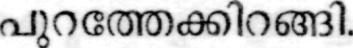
പുറത്തേക്കിറങ്ങി.
